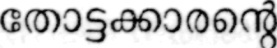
തോട്ടക്കാരന്റെ
